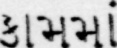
કામમાં
